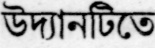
উদ্যানটিতে
